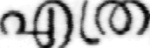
എത്ര
